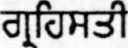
ਗ੍ਰਹਿਸਤੀ
